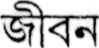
জীবন
